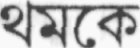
থমকে
